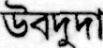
উবদুদা
